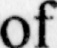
of
